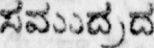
ಸಮುದ್ರದ
